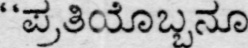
“ಪ್ರತಿಯೊಬ್ಬನೂ
